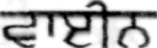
ਵਾਈਨ
